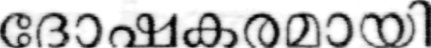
ദോഷകരമായി
